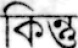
কিন্তু
